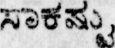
ಸಾಕಷ್ಟು
